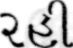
રહી
